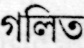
গলিত
